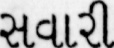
સવારી
